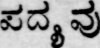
ಪದ್ಯವು
